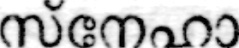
സ്നേഹാ
